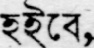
হইবে,
